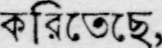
করিতেছে,
